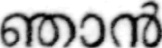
ഞാന്‍
